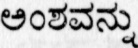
ಅಂಶವನ್ನು
